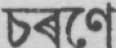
চৰণে
